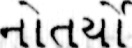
નોતર્યો
